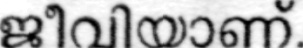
ജീവിയാണ്.
